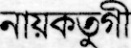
নায়কতুগী
